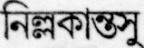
নিল্লকান্তসু
